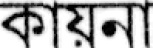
কায়না
